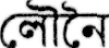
লৌনৈ
